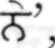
ਨੇ',
